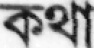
কথা
